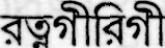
রত্নগীরিগী
